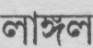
লাঙ্গল
